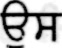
ਉਸ
